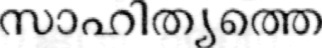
സാഹിത്യത്തെ
